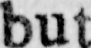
but
